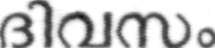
ദിവസം
